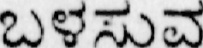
ಬಳಸುವ
